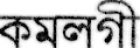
কমলগী
